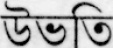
উভতি
